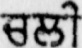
ਚਲੀ
